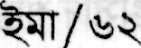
ইমা/৬২
